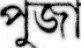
পুজা
